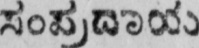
ಸಂಪ್ರದಾಯ
